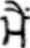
ਮੈਂ
